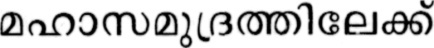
മഹാസമുദ്രത്തിലേക്ക്
